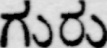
ಗುರು
